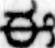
ಈ
